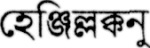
হেঞ্জিল্লক্কনু
